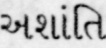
અશાંતિ
